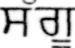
ਸੱਗੂ
